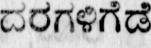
ದರಗಳಿಗೆಡೆ
